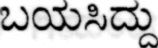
ಬಯಸಿದ್ದು
